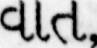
વાત,
